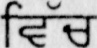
ਵਿੱਚ
